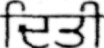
ਦਿਤੀ
